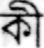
কী
